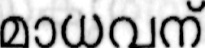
മാധവന്
